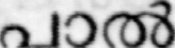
പാല്‍
